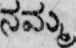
ನಮ್ಮ
